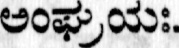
ಅಂಘ್ರಯಃ
